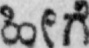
ಹೀಗೆ
